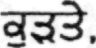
ਕੁੜਤੇ,
